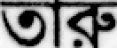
তারু
